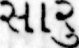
સારુ
